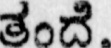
ತಂದೆ.
